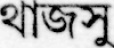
থাজসু
